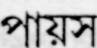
পায়স
